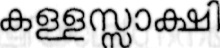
കള്ളസ്സാക്ഷി
